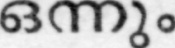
ഒന്നും
